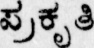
ಪ್ರಕೃತಿ
